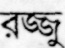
রজ্জু
